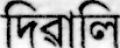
দিৱালি
